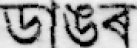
ডাঙৰ
